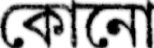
কোনো
